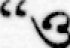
“ও
